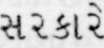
સરકારે
